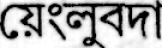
য়েংলুবদা
